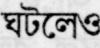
ঘটলেও
